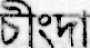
চীংদা
